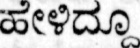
ಹೇಳಿದ್ದೂ
